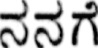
ನನಗೆ
